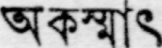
অকস্মাৎ
